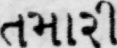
તમારી
